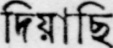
দিয়াছি
